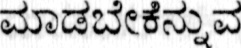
ಮಾಡಬೇಕೆನ್ನುವ
